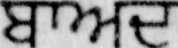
ਬਾਅਦ
